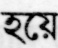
হয়ে
